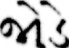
જોડે
